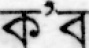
ক'ব
